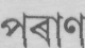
পৰাণ
